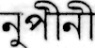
নুপীনী
